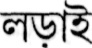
লড়াই
